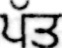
ਪੱਤ
